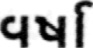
વર્ષા
